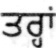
ਤਰ੍ਹਾਂ
